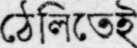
ঠেলিতেই
